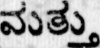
ಮತ್ತು
